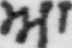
ਆ
